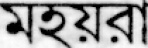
মহয়রা
